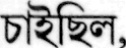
চাইছিল,
